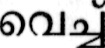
വെച്ച്
